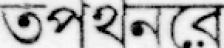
তপথনরে
